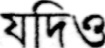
যদিও
